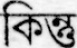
কিন্তু
